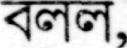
বলল,
